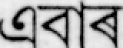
এবাৰ
